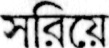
সরিয়ে
